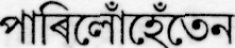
পাৰিলোঁহেঁতেন
